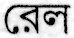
রেল
